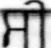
ਸੀ
